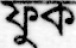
ফুক
